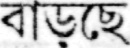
বাড়ছে
